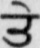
ਤੇ
